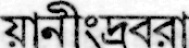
য়ানীংদ্রবরা
